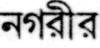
নগরীর
